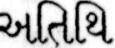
અતિથિ
